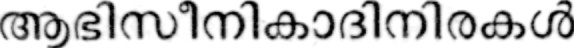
ആഭിസീനികാദിനിരകള്‍
